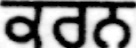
ਕਰਨ
